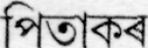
পিতাকৰ
